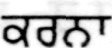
ਕਰਨਾ
